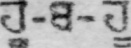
ਹੂ-ਬ-ਹੂ
